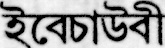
ইবাচাউবী
